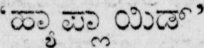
‘ಹ್ಯಾಪ್ಲಾಯಿಡ್’
